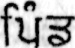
ਪਿੰਡ
